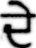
ਦੇ
